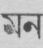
মন
